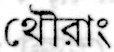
থৌরাং
